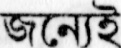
জন্যেই
